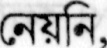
নেয়নি,
